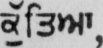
ਕੁੱਤਿਆ,
